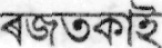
ৰজতকাই
